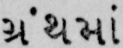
ગ્રંથમાં
